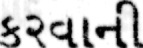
કરવાની
